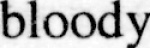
bloody
